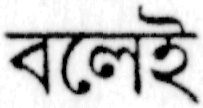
বলেই
